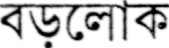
বড়লোক
